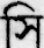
সি
